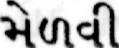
મેળવી
